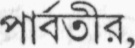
পার্বতীর,
